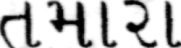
તમારા
